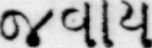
જવાય
